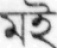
মই
